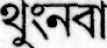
থুংনবা
